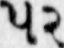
પર
